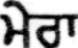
ਮੇਰਾ
